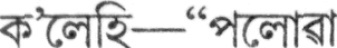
ক'লেহি-"পলোৱা
